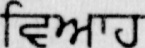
ਵਿਆਹ
